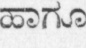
ಹಾಗೂ
